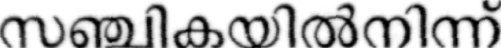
സഞ്ചികയില്‍നിന്ന്
